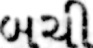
બચી
